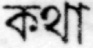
কথা
